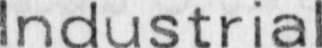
Industrial
